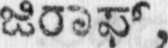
ಜಿರಾಫ್,
